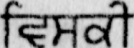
ਵਿਸਕੀ
